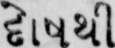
દોષથી
